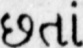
છતાં
